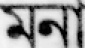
মনা
